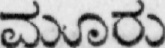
ಮೂರು
